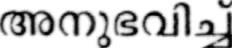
അനുഭവിച്ച്
